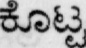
ಕೊಟ್ಟ
